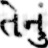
તેનું
